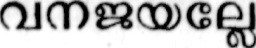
വനജയല്ലേ
